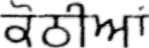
ਕੋਠੀਆਂ
